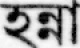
হন্না
